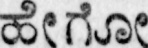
ಹೇಗೋ
